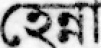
হেন্না
